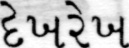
દેખરેખ
